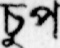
চুপ
